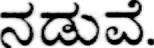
ನಡುವೆ.
